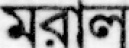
মরাল
